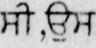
ਸੀ,ਉਸ
